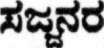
ಸಜ್ಜನರ
